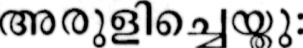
അരുളിച്ചെയ്തു:
